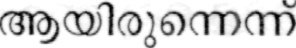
ആയിരുന്നെന്ന്
